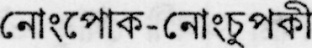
নোংপোক-নোংচুপকী
